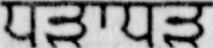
ਧੜਾਧੜ
